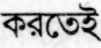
করতেই
